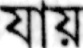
যায়
